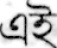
এই
